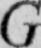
G
